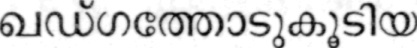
ഖഡ്ഗത്തോടുകൂടിയ
